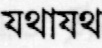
যথাযথ
